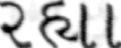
રહ્યા
